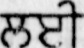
ਲਈ
